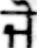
ਜੋ
